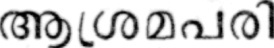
ആശ്രമപരി
